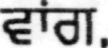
ਵਾਂਗ,
